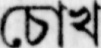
চোখ
